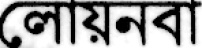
লোয়ননা
